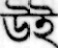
উই
